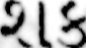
શક
